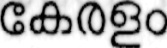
കേരളം
